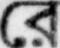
রে
